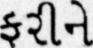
ફરીને
